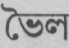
ভৈল
